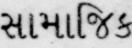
સામાજિક
